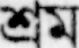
শ্রম
